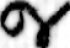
જ
